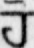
ਹੋ
